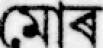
মোৰ
